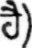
ਹੈ)
